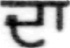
ਦਾ
